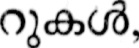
റുകള്‍,
